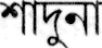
শাদুনা
